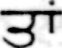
ਤਾਂ
